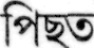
পিছত
